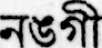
নঙগী
